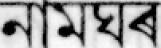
নামঘৰ
